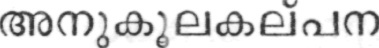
അനുകൂലകല്പന
